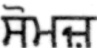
ਸੋਮਜ਼
